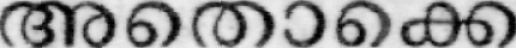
അതൊക്കെ
